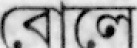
বোলে
